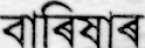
বাৰিষাৰ
